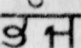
ਭੱਜ
